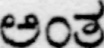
ಅಂತ
